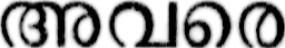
അവരെ
